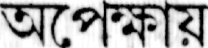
অপেক্ষায়
